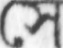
সে
